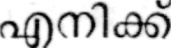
എനിക്ക്
